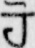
ਹੋ
